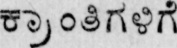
ಕ್ರಾಂತಿಗಳಿಗೆ
